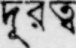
দূরত্ব
